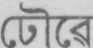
ঢৌৱে
